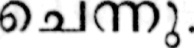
ചെന്നു.
